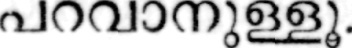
പറവാനുള്ളൂ.
